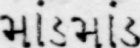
માંડમાંડ
